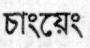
চাংয়েং
